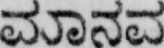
ಮಾನವ
